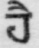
ਹੈ
